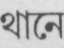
থানে
